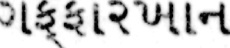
ગફ્ફારખાન
